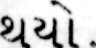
થયો.
